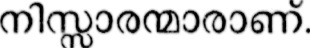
നിസ്സാരന്മാരാണ്.
